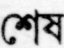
শেষ
